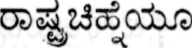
ರಾಷ್ಟ್ರಚಿಹ್ನೆಯೂ
